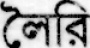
লৈরি
